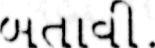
બતાવી.
